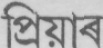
প্ৰিয়াৰ
